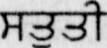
ਸਤੁਤੀ
